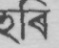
হৰি
